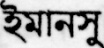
ইমানসু
